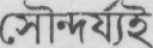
সৌন্দৰ্য্যই
